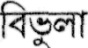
বিভুলা
